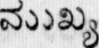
ಮುಖ್ಯ
